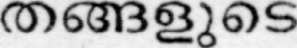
തങ്ങളുടെ
